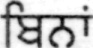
ਬਿਨਾਂ
